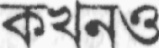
কখনও
